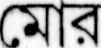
মোর
